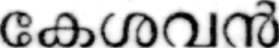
കേശവന്‍
